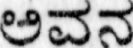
ಅವನ
